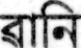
ৱানি
